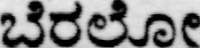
ಬೆರಲೋ
